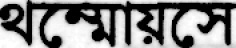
থম্মোয়সে
